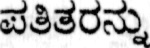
ಪತಿತರನ್ನು
